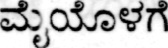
ಮೈಯೊಳಗೆ
